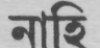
নাহি
